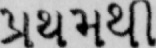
પ્રથમથી
